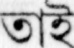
তাই
